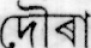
দৌৰা
